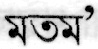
মতম’
